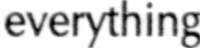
everything
